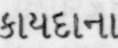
કાયદાના
